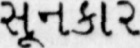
સૂનકાર
